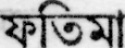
ফতিমা
